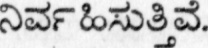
ನಿರ್ವಹಿಸುತ್ತಿವೆ.
